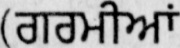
(ਗਰਮੀਆਂ
